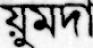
য়ুমদা
